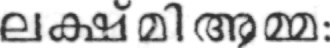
ലക്ഷ്മിഅമ്മ:
